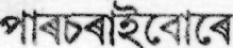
পাৰচৰাইবোৰে
